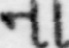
ના
